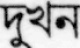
দুখন
